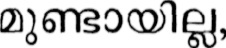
മുണ്ടായില്ല,
